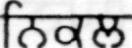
ਨਿਕਲ
